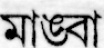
মাঙবা
